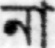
না
